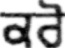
ਕਰੋ
